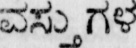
ವಸ್ತುಗಳ
